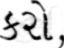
કરો,
